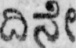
ದಿನೇ
